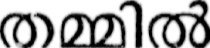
തമ്മില്‍
